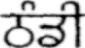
ਠੰਡੀ
